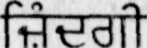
ਜ਼ਿੰਦਗੀ
